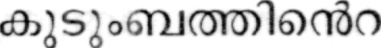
കുടുംബത്തിന്റെ
